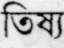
তিষ্য
